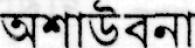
অশাউবনা
